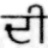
ਦੀ
